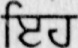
ਇਹ
